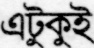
এটুকুই
